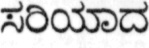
ಸರಿಯಾದ
